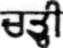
ਚੜ੍ਹੀ
